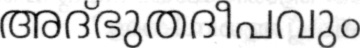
അദ്ഭുതദീപവും
